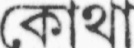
কোথা
